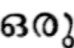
ഒരു
